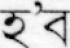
হ'ব
